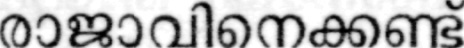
രാജാവിനെക്കണ്ട്
